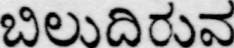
ಬಿಲುದಿರುವ
